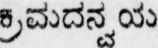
ಕ್ರಮದನ್ವಯ
